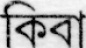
কিবা
